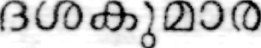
ദശകുമാര
